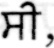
ਸੀ,
